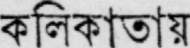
কলিকাতায়
